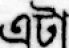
এটা
